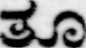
ತೂ
